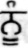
ਨੂੰ
